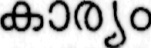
കാര്യം
